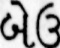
બેઉ
